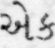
એક
